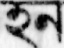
হন
